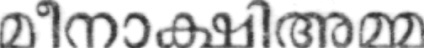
മീനാക്ഷിഅമ്മ
